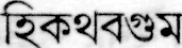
হিকথবগুম
